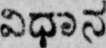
ವಿಧಾನ
